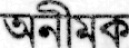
অনীমক
